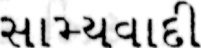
સામ્યવાદી
